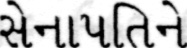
સેનાપતિને
